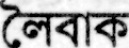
লৈবাক
